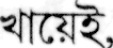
খায়েই,
